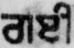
ਗਈ
